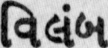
વિલંબ
